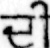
ਦੀ
